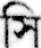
সি
